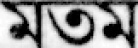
মতম
